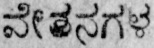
ವೇತನಗಳ
